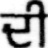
ਦੀ
